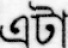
এটা
